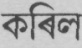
কৰিল
